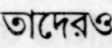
তাদেরও
